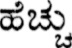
ಹೆಚ್ಚು
